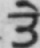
ਤੇ
